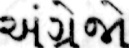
અંગ્રેજો
